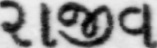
રાજીવ
